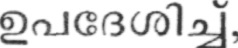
ഉപദേശിച്ച്,
